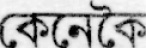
কেনেকৈ
